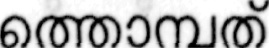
ത്തൊമ്പത്
